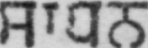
ਸਾਧਨ
